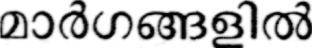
മാര്‍ഗങ്ങളില്‍
